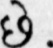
છે.
